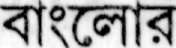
বাংলোর
